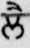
ਲੈ
